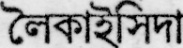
লৈকাইসিদা
